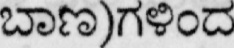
ಬಾಣ)ಗಳಿಂದ
